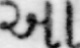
આ
